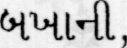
બખાની,
